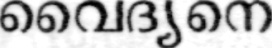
വൈദ്യനെ
